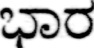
ಭಾರ
